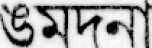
ঙমদনা
